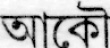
আকৌ
